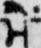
ਮੈਂ
